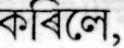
কৰিলে,
